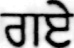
ਗਏ
